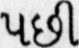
પછી
